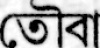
তৌবা
